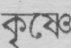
কৃষ্ণে
